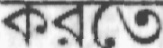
করতে
